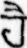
ਹੈ
